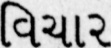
વિચાર
